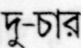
দু-চার
